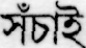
সঁচাই
